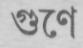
গুণে
